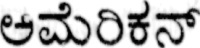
ಅಮೆರಿಕನ್
